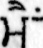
ਮੈਂ
